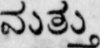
ಮತ್ತು
